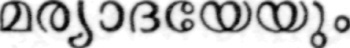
മര്യാദയേയും
